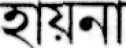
হায়না
